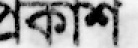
প্ৰকাশ
